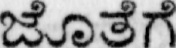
ಜೊತೆಗೆ
